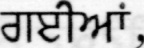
ਗਈਆਂ,
